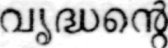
വൃദ്ധന്റെ
